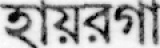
হায়রগা
